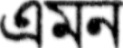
এমন
